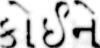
કોઈને
